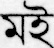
মই
